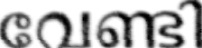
വേണ്ടി
